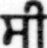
ਸੀ
